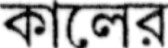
কালের
